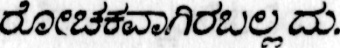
ರೋಚಕವಾಗಿರಬಲ್ಲದು
